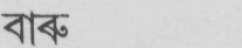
বাৰু
